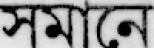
সমানে
